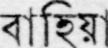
বাহিয়া
